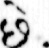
છે.
